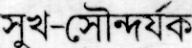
সুখ-সৌন্দর্যক
